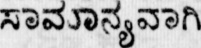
ಸಾಮಾನ್ಯವಾಗಿ
